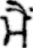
ਮੈਂ
